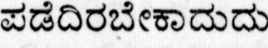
ಪಡೆದಿರಬೇಕಾದುದು
